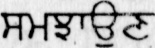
ਸਮਝਾਉਣ
